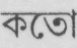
কতো
